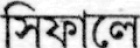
সিফালে
